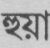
হুয়া
